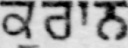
ਕੁਰਾਨ
